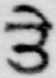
ਤੇ
